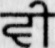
ਵੀ
